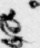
હું
